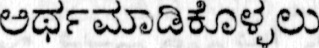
ಅರ್ಥಮಾಡಿಕೊಳ್ಳಲು
